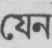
যেন
